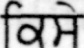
ਕਿਸੇ
